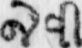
જેવી
